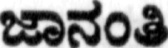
ಜಾನಂತಿ
